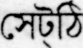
সেট্ঠি
